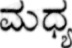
ಮಧ್ಯ
